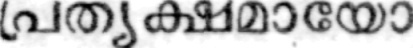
പ്രത്യക്ഷമായോ
